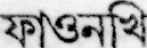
ফাওনখি
